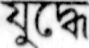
যুদ্ধে
